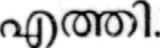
എത്തി.
